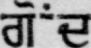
ਗੋਂਦ
